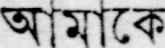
আমাকে
